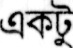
একটু
